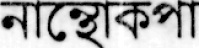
নান্থোকপা
